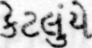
કેટલુંયે
